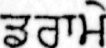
ਡਰਾਮੇ
